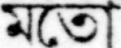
মতো
